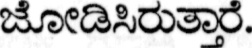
ಜೋಡಿಸಿರುತ್ತಾರೆ.
